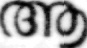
ആ
